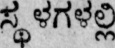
ಸ್ಥಳಗಳಲ್ಲಿ
